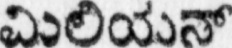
ಮಿಲಿಯನ್
